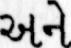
અને
